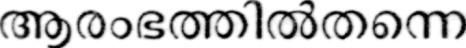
ആരംഭത്തില്‍തന്നെ
